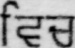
ਵਿਚ
